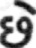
છે
